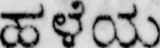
ಹಳೆಯ
